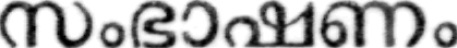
സംഭാഷണം
